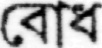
বোধ
